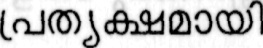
പ്രത്യക്ഷമായി
